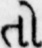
તો
